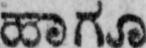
ಹಾಗೂ
